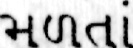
મળતાં
